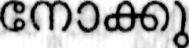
നോക്കു
